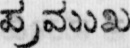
ಪ್ರಮುಖ
